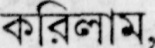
করিলাম,
